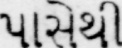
પાસેથી
